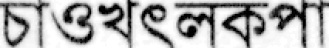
চাওখৎলকপা
